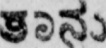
ತಾನು
